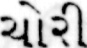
ચોરી
